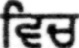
ਵਿਚ
